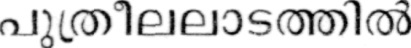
പുത്രീലലാടത്തില്‍
